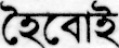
হৈবোই
